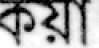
কয়া
